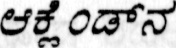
ಆಕ್ಲೆಂಡ್ನ
